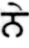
ਨੇ
